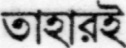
তাহারই
